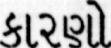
કારણો
